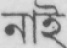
নাই
